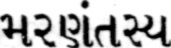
મરણંતસ્ય
